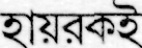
হায়রকই
